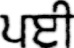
ਪਈ
